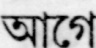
আগে
